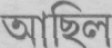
আছিল
